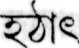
হঠাৎ
